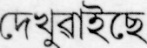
দেখুৱাইছে
